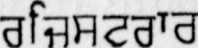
ਰਜਿਸਟਰਾਰ
